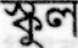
স্কুল
